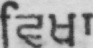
ਵਿਖਾ
